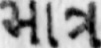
માત્ર
